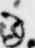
છે.
